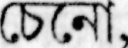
চেনো,
